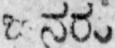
ಜನರು
